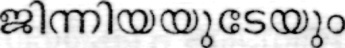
ജിന്നിയയുടേയും
